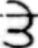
ਤੇ
